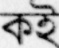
কই
